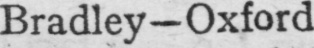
Bradley-Oxford
